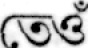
তেওঁ
